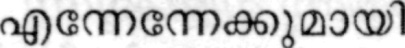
എന്നേന്നേക്കുമായി
